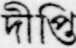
দীপ্তি
